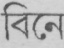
বিনে
